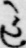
હે
